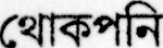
থোকপনি
